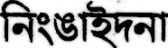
নিংঙাইদনা
